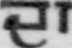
ਦਾ
